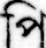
পি
